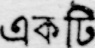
একটি
